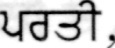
ਪਰਤੀ,
